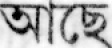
আছে
